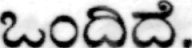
ಒಂದಿದೆ.
